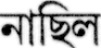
নাছিল
